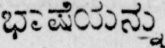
ಭಾಷೆಯನ್ನು
